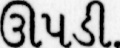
ઊપડી.
